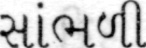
સાંભળી
